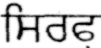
ਸਿਰਫ਼
